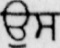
ਉਸ
